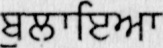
ਬੁਲਾਇਆ
